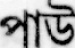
পাউ
